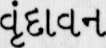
વૃંદાવન
